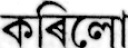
কৰিলো
